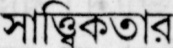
সাত্ত্বিকতার
